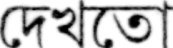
দেখতো
